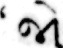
'જો
